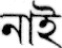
নাই
